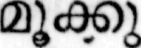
മൂക്കു
